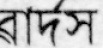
ৱার্দস
